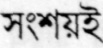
সংশয়ই
